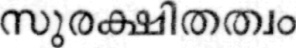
സുരക്ഷിതത്വം
